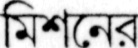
মিশনের
